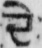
ਦੇ
